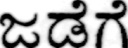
ಜಡೆಗೆ
